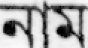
নাম
